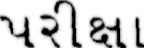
પરીક્ષા
